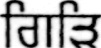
ਗਿੜਿ
